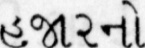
હજારનો
